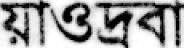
য়াওদ্রবা
